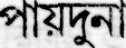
পায়দুনা
